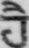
ਹੈ
